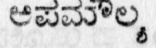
ಅಪಮೌಲ್ಯ
